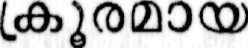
ക്രൂരമായ
